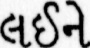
લઈને
